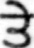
ਤੇ
